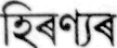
হিৰণ্যৰ
